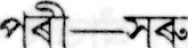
পৰী-সৰু
